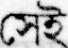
সেই
